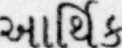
આર્થિક
